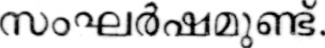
സംഘര്‍ഷമുണ്ട്.
